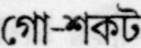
গো-শকট
